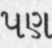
પણ
